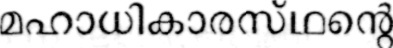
മഹാധികാരസ്ഥന്റെ
